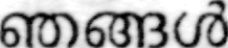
ഞങ്ങള്‍
